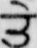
ਤੇ
